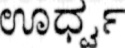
ಊರ್ಧ್ವ
